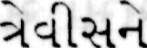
ત્રેવીસને
